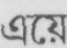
এয়ে
